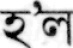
হ'ল
